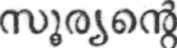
സൂര്യന്റെ
